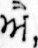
ਐ,
